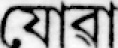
যোৱা
